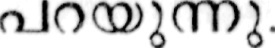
പറയുന്നു.
